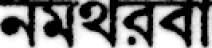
নমথরবা
